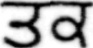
ਤਕ
